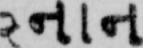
સ્નાન
